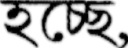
হচ্ছে,
